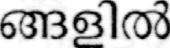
ങ്ങളില്‍
